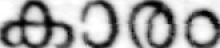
കാരം
